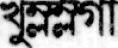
খুম্লম্লগা
